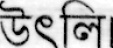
উৎলি।
